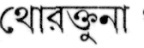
থোরক্তুনা
